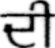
ਦੀ
